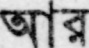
আর
